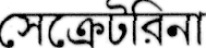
সেক্রেটরিনা
